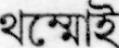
থম্মোই
